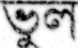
ভুল
